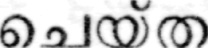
ചെയ്ത
